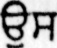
ਉਸ
